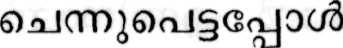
ചെന്നുപെട്ടപ്പോള്‍
